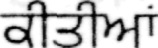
ਕੀਤੀਆਂ
